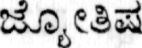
ಜ್ಯೋತಿಷ
